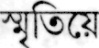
স্মৃতিয়ে
